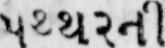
પથ્થરની
